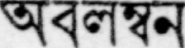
অবলম্বন
